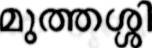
മുത്തശ്ശി
